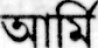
আর্মি
